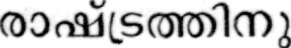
രാഷ്ട്രത്തിനു
